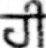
ਹੀ
